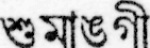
শুমাঙগী
